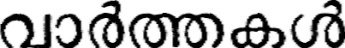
വാര്‍ത്തകള്‍
